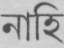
নাহি
